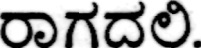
ರಾಗದಲಿ.
